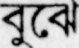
বুঝে
